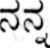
ನನ್ನ
